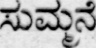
ಸುಮ್ಮನೆ
